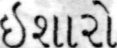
ઇશારો
